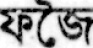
ফজৈ
